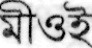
মীওই
